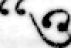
“ও
